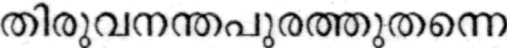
തിരുവനന്തപുരത്തുതന്നെ
